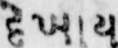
દેખાય
